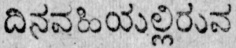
ದಿನವಹಿಯಲ್ಲಿರುವ
